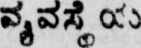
ವ್ಯವಸ್ಥೆಯ
